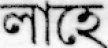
লাহে
